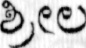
ಶ್ರೀಲ
